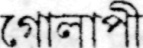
গোলাপী
